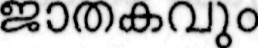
ജാതകവും
